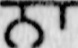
ਨਾ
